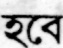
হবে
